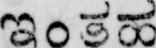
ಇಂತಹ
